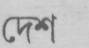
দেশ
